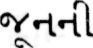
જૂનની
